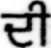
ਦੀ
